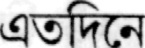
এতদিনে
